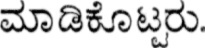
ಮಾಡಿಕೊಟ್ಟರು.
